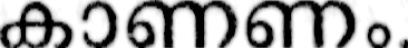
കാണണം.
